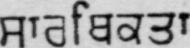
ਸਾਰਥਿਕਤਾ
